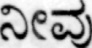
ನೀವು
